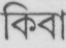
কিবা
